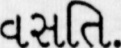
વસતિ.
